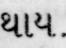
થાય.
